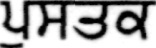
ਪੁਸਤਕ
